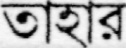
তাহার
